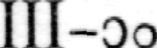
III-ാം
